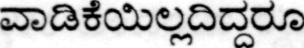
ವಾಡಿಕೆಯಿಲ್ಲದಿದ್ದರೂ
